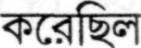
করেছিল
